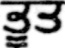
ਭੂਤ
